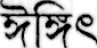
ঈঙ্গিৎ
